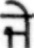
ਜੇ
